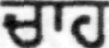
ਚਾਹ
